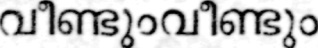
വീണ്ടുംവീണ്ടും
